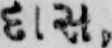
દાસ,
